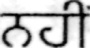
ਨਹੀਂ
